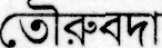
তৌরুবদা
